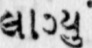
લાગ્યું
